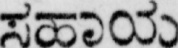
ಸಹಾಯ
